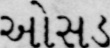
ઓસડ
